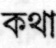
কথা
